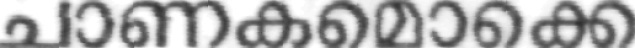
ചാണകമൊക്കെ
